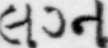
લગ્ન
